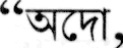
“অদো,
